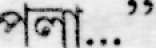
পলা..."
